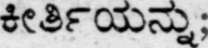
ಕೀರ್ತಿಯನ್ನು;
